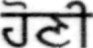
ਹੋਣੀ
